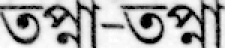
তপ্না-তপ্না
